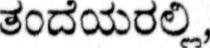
ತಂದೆಯರಲ್ಲಿ,
